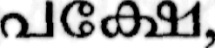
പക്ഷേ,
